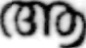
ആ
